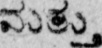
ಮತ್ತು
